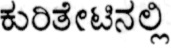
ಕುರಿತೇಟಿನಲ್ಲಿ
